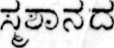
ಸ್ಮಶಾನದ
